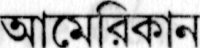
আমেরিকান
